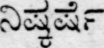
ನಿಷ್ಕರ್ಷೆ
